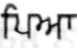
ਪਿਆ
